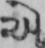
એ
